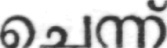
ചെന്ന്
